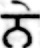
ਨੇ
